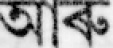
আৰু
